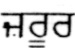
ਜ਼ਰੂਰ
